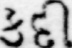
કદી
